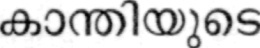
കാന്തിയുടെ
